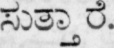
ಸುತ್ತಾರೆ.
